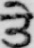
ਤੇ
